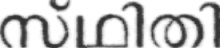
സ്ഥിതി
